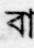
বা
